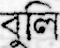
বুলি
